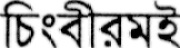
চিংবীরমই
